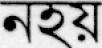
নহয়
